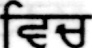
ਵਿਚ
